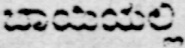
ಬಾಯಿಯಲ್ಲಿ
